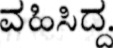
ವಹಿಸಿದ್ದ.
